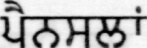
ਪੈਨਸਲਾਂ
